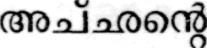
അച്ഛന്റെ
